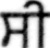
ਸੀ
